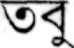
তবু
